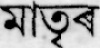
মাতৃৰ
